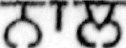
ਨਾਲ
